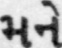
મને
